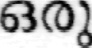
ഒരു
